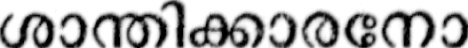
ശാന്തിക്കാരനോ
